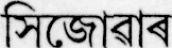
সিজোৱাৰ
